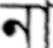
না
